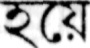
হয়ে
